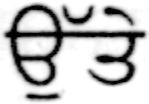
ਉੱਤੇ
